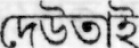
দেউতাই
